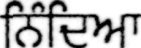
ਨਿੰਦਿਆ
